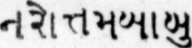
નરોત્તમબાબુ
